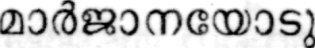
മാര്‍ജാനയോടു
